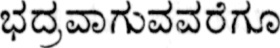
ಭದ್ರವಾಗುವವರೆಗೂ
